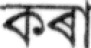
কৰা
